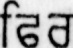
ਫਿਰ
